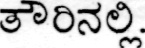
ತೌರಿನಲ್ಲಿ.
